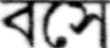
বসে
